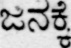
ಜನಕ್ಕೆ
